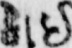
કોઈ
